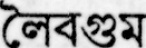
লৈবগুম
